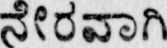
ನೇರವಾಗಿ
